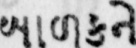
બાળકને
